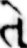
તે
